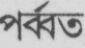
পৰ্ব্বত
